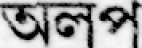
অলপ
